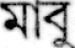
মাবু
